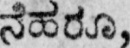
ನೆಹರೂ,
